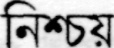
নিশ্চয়
